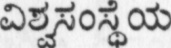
ವಿಶ್ವಸಂಸ್ಥೆಯ
